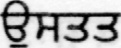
ਉਸਤਤ
